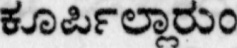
ಕೂರ್ಪಿಲ್ಲಾರುಂ
